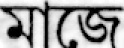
মাজে
